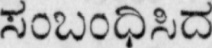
ಸಂಬಂಧಿಸಿದ
